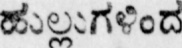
ಹುಲ್ಲುಗಳಿಂದ
